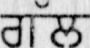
ਗੱਲ
